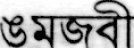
ঙমজবী
